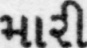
મારી
